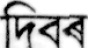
দিবৰ
